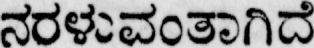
ನರಳುವಂತಾಗಿದೆ
